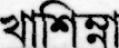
খাশিম্না
